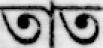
তাত
